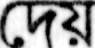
দেয়
